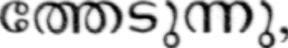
ത്തേടുന്നു,
